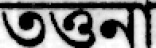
তত্তনা
